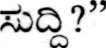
ಸುದ್ದಿ?"
